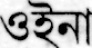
ওইনা
